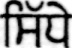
ਸਿੱਧੇ
